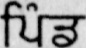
ਪਿੰਡ
